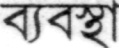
ব্যবস্থা
